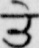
ਤੇ
